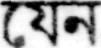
যেন
